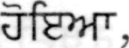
ਹੋਇਆ,
